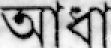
আধা
